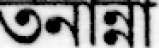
তনান্না
